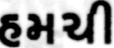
હમચી
